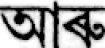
আৰু
